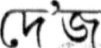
দে’জ
